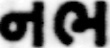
નભ
